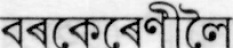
বৰকেৰেণীলৈ
